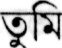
তুমি
